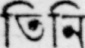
তিনি
